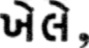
ખેલે,
